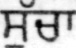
ਸੁੱਚਾ
